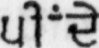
ਪੀਂਦੇ
